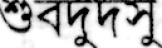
শুবদুদসু
